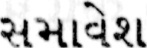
સમાવેશ
